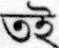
তই
